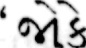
'જોકે
